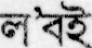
ল'বই
